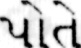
પોતે
